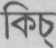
কিচ্
